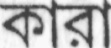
কারা
